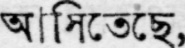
আসিতেছে,
